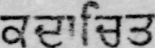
ਕਦਾਚਿਤ
